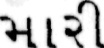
મારી
